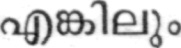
എങ്കിലും
